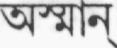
অস্মান্
